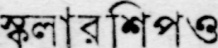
স্কলারশিপও
